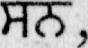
ਸਨ,
